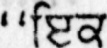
''ਇਕ
